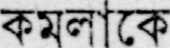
কমলাকে
